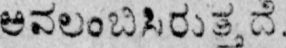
ಅವಲಂಬಿಸಿರುತ್ತದೆ.
